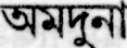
অমদুনা
